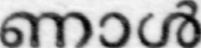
ണാള്‍
